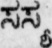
ಸಸ್ಯ
